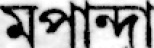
মপান্দা
